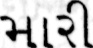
મારી
